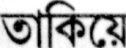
তাকিয়ে
